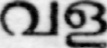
വള
